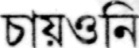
চায়ওনি
